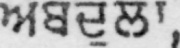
ਅਬਦੁਲਾ,
